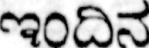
ಇಂದಿನ
